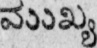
ಮುಖ್ಯ
